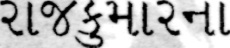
રાજકુમારના
